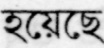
হয়েছে
